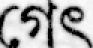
গেৎ
